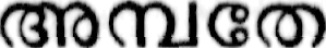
അമ്പതേ
